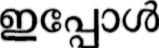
ഇപ്പോള്‍
